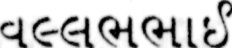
વલ્લભભાઈ
